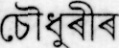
চৌধুৰীৰ
